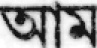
আম
